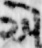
એ
